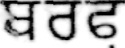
ਬਰਫ਼
